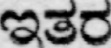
ಇತರ
